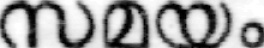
സമയം
